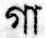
গা
